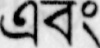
এবং
